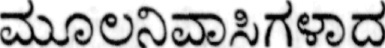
ಮೂಲನಿವಾಸಿಗಳಾದ
